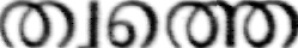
ത്വത്തെ
